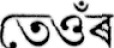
তেওঁৰ
